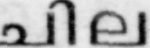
ചില
